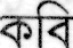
কবি
